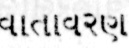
વાતાવરણ
